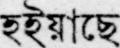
হইয়াছে
